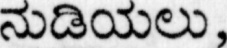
ನುಡಿಯಲು,
